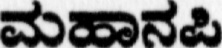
ಮಹಾನಪಿ
